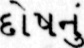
દોષનું
